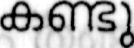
കണ്ടു
